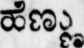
ಹೆಣ್ಣು
